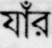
যাঁর
